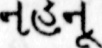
નહનૂ
